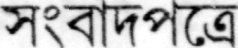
সংবাদপত্রে
